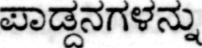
ಪಾಡ್ದನಗಳನ್ನು
